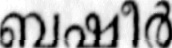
ബഷീര്‍
